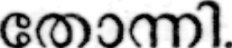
തോന്നി.
